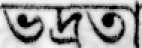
ভদ্রতা
